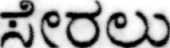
ಸೇರಲು
